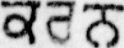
ਕਰਨ
